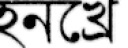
হনখ্রে
